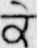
ਕੇ
